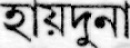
হায়দুনা
